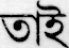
তাই
